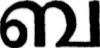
ബ
